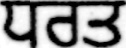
ਧਰਤ
